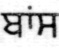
ਬਾਂਸ
